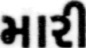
મારી
